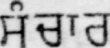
ਸੰਚਾਰ
